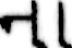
ના
